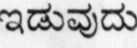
ಇಡುವುದು
